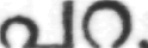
പറ.
